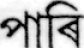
পাৰি
